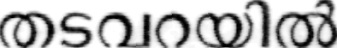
തടവറയില്‍
